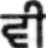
ਵੀ
